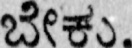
ಬೇಕು.
